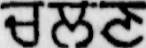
ਚਲਣ
